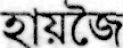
হায়জৈ
